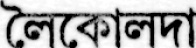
লৈকোলদা
